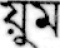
য়ুম
